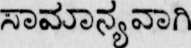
ಸಾಮಾನ್ಯವಾಗಿ
